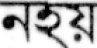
নহয়
